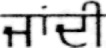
ਜਾਂਦੀ
